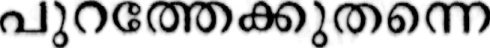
പുറത്തേക്കുതന്നെ
